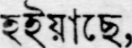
হইয়াছে,
